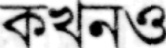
কখনও
